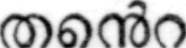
തന്റെ
